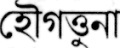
হৌগত্তুনা
